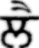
ਲੈ
